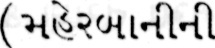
(મહેરબાનીની
